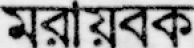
মরায়বক
